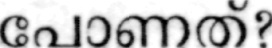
പോണത്?
